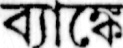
ব্যাঙ্কে
